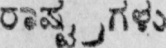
ರಾಷ್ಟ್ರಗಳು
